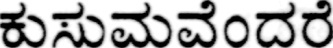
ಕುಸುಮವೆಂದರೆ
